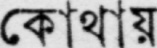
কোথায়
